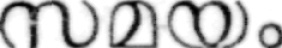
സമയം
